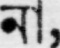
না,
